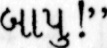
બાપુ!"
